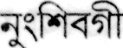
নুংশিবগী
